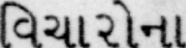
વિચારોના
